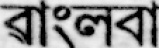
ৱাংলবা
